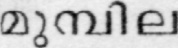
മുമ്പില
